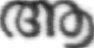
ആ
